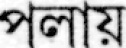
পলায়
